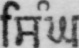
ਸਿੰਘ
